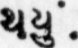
થયું.
